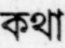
কথা
